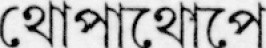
থোপাথোপে
